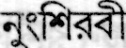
নুংশিরবী
